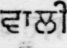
ਵਾਲੀ
